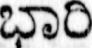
ಭಾರಿ
